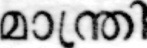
മാന്ത്രി
